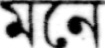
মনে
